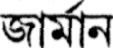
জার্মান
